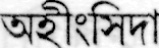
অহীংসিদা
